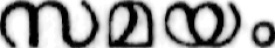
സമയം
